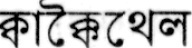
ক্বাক্কৈথেল
